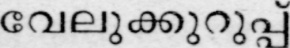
വേലുക്കുറുപ്പ്
